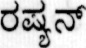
ರಷ್ಯನ್
